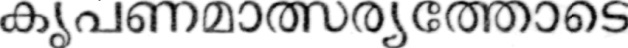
കൃപണമാത്സര്യത്തോടെ
